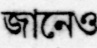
জানেও
